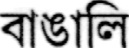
বাঙালি
